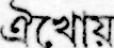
ঐখোয়
